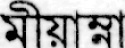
মীয়াম্না
